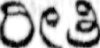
ರೀತಿ
